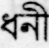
ধনী
